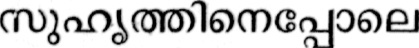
സുഹൃത്തിനെപ്പോലെ
